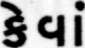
કેવાં
